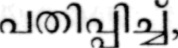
പതിപ്പിച്ച്,
